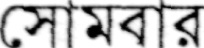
সোমবার
